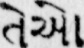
તેઓ
